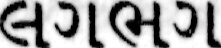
લગભગ
